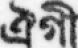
ঐগী
